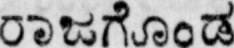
ರಾಜಗೊಂಡ
